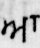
ਆ
